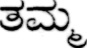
ತಮ್ಮ
